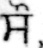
ਸੌ,
